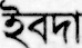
ইবদা
